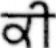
ਕੀ
